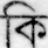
কি
